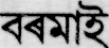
বৰমাই
